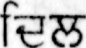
ਦਿਲ
